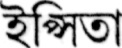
ইপ্সিতা
